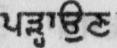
ਪੜ੍ਹਾਉਣ
